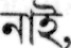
নাই,
